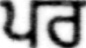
ਪਰ
